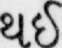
થઈ
